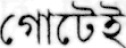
গোটেই
